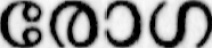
രോഗ
